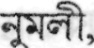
নুমলী,
